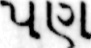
પણ
